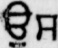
ਉਸ
